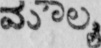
ಮೌಲ್ಯ
